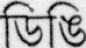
ডিঙি
